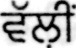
ਵੱਲ਼ੀਂ
